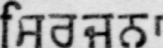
ਸਿਰਜਨਾ
